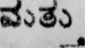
ಮತ್ತು
